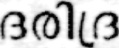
ദരിദ്ര
